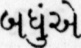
બધુંએ
